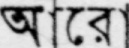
আরো
